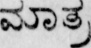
ಮಾತ್ರ
